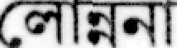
লোন্ননা
